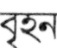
বৃহন
